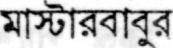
মাস্টারবাবুর
